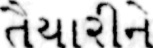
તૈયારીને
